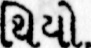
થિયો.
